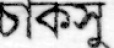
চাকসু
